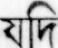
যদি
